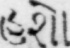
હશો
